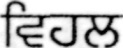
ਵਿਹਲ
